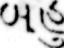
બહુ
